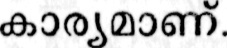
കാര്യമാണ്.
